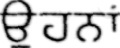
ਉਹਨਾਂ
